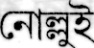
নোল্লুই
